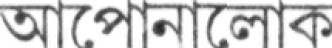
আপোনালোক
